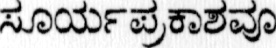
ಸೂರ್ಯಪ್ರಕಾಶವೂ
